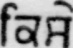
ਕਿਸੇ
